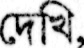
দেখি,
